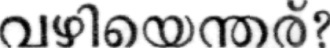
വഴിയെന്തര്?
